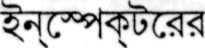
ইন্স্পেক্‌টরের
